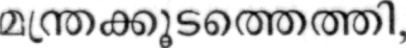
മന്ത്രക്കൂടത്തെത്തി,
